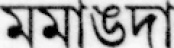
মমাঙদা
